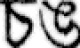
চঙ
